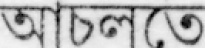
আচলতে
